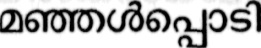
മഞ്ഞള്‍പ്പൊടി
